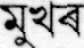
মুখৰ
